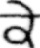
ਕੇ
